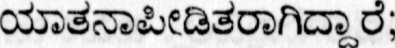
ಯಾತನಾಪೀಡಿತರಾಗಿದ್ದಾರೆ;
